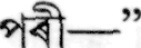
পৰী-"
